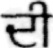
ਦੀ
